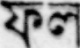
ফল
